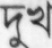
দুখ
